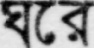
ঘরে
